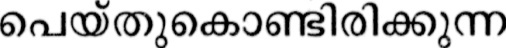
പെയ്തുകൊണ്ടിരിക്കുന്ന
